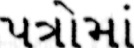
પત્રોમાં
